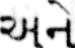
અને
